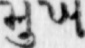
મુખ
